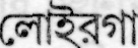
লোইরগা
